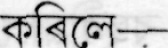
কৰিলে-
